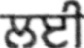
ਲਈ
